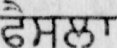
ਫੈਸਲਾ
